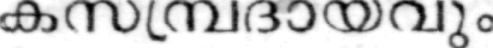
കസമ്പ്രദായവും
